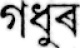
গধুৰ
